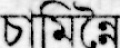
চামিন্নৈ
